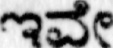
ಇವೇ
